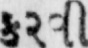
કરવી
